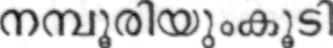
നമ്പൂരിയുംകൂടി
